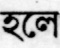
হলে
